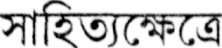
সাহিত্যক্ষেত্রে
